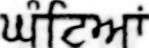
ਘੰਟਿਆਂ
